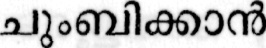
ചുംബിക്കാന്‍
